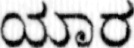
ಯಾರ
